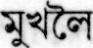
মুখলৈ
